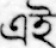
এই
